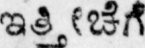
ಇತ್ತೀಚೆಗೆ
